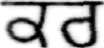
ਕਰ
